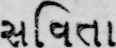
સવિતા
